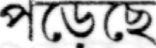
পড়েছে
